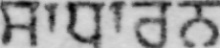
ਸਾਧਾਰਨ
